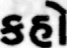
કહો
